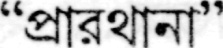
‘‘প্রারথানা’’
